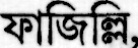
ফাজিল্লি,
